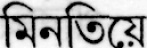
মিনতিয়ে
